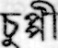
চুপ্পী
